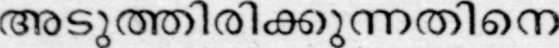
അടുത്തിരിക്കുന്നതിനെ
